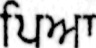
ਪਿਆ
